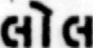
લોલ
